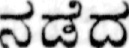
ನಡೆದ
